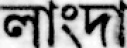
লাংদা
